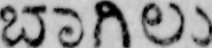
ಬಾಗಿಲು
